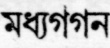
মধ্যগগন
